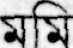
মমি
